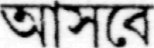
আসবে
